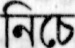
নিচে
